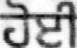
ਹੋਈ
